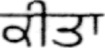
ਕੀਤਾ
